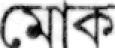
মোক
